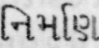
નિર્માણ
